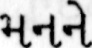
મનને
